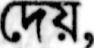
দেয়,
